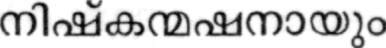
നിഷ്കന്മഷനായും
